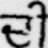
ਦੀ
